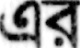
এর
